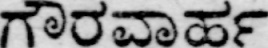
ಗೌರವಾರ್ಹ
